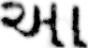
આ
